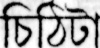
চিঠিটা
